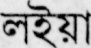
লইয়া
